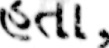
હતા,
